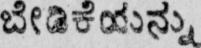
ಬೇಡಿಕೆಯನ್ನು
